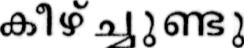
കീഴ്ച്ചുണ്ടു
